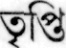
তৃপ্তি
